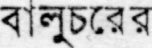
বালুচরের
